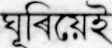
ঘূৰিয়েই
